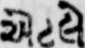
એટલે
